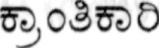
ಕ್ರಾಂತಿಕಾರಿ
